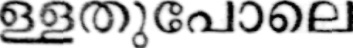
ള്ളതുപോലെ
